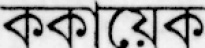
ককায়েক
